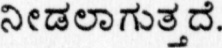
ನೀಡಲಾಗುತ್ತದೆ.
